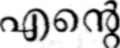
എന്റെ
